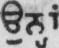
ਉਨ੍ਹਾਂ
